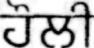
ਹੌਲੀ
